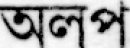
অলপ
